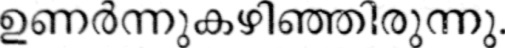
ഉണര്‍ന്നുകഴിഞ്ഞിരുന്നു.
